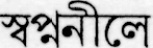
স্বপ্ননীলে
